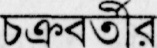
চক্রবর্তীর
